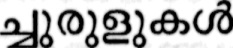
ച്ചുരുളുകള്‍
